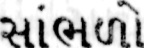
સાંભળો
